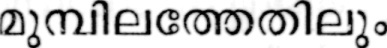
മുമ്പിലത്തേതിലും
